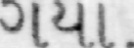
ગયા.
